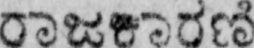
ರಾಜಕಾರಣಿ
